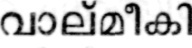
വാല്മീകി
